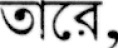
তারে,
